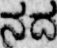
ನದ
